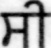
ਸੀ
